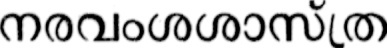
നരവംശശാസ്ത്ര
